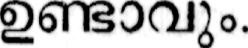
ഉണ്ടാവും.
